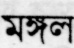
মঙ্গল
